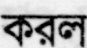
করল
